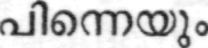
പിന്നെയും
